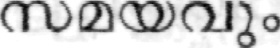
സമയവും
